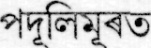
পদূলিমূৰত
